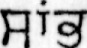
ਸਾਂਭ
